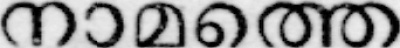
നാമത്തെ
